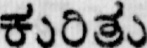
ಕುರಿತು
